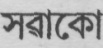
সৱাকো
